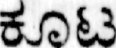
ಕೂಟ
